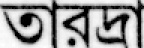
তারদ্রা
